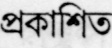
প্রকাশিত
